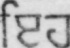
ਇਹ
